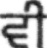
ਵੀ
